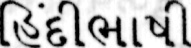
હિંદીભાષી
